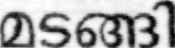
മടങ്ങി
